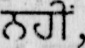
ਨਹੀਂ,
